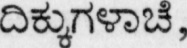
ದಿಕ್ಕುಗಳಾಚೆ,
